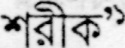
শরীক’১
